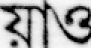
য়াও
